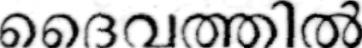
ദൈവത്തില്‍
